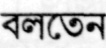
বলতেন
